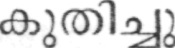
കുതിച്ചു
